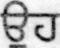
ਉਹ
